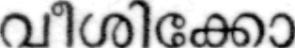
വീശിക്കോ
